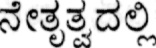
ನೇತೃತ್ವದಲ್ಲಿ
